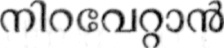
നിറവേറ്റാന്‍
